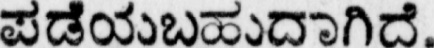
ಪಡೆಯಬಹುದಾಗಿದೆ.
